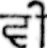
ਵੀ
